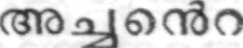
അച്ചന്റെ
